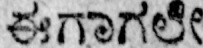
ಈಗಾಗಲೇ
